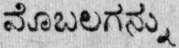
ಮೊಬಲಗನ್ನು
